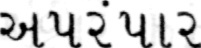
અપરંપાર
